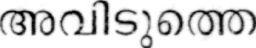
അവിടുത്തെ
